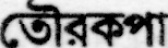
তৌরকপা
